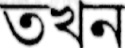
তখন
